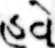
હવે
